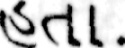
હતા.
